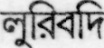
লুরিবদি
